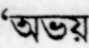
‘অভয়
